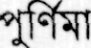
পুর্ণিমা
